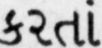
કરતાં
